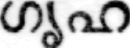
ഗൃഹ
